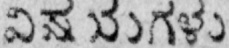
ವಿಷಯಗಳು
